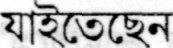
যাইতেছেন
